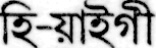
হি-য়াইগী
